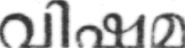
വിഷമ
